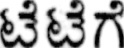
ಟೆಟೆಗೆ
